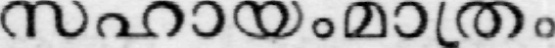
സഹായംമാത്രം
